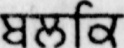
ਬਲਕਿ
